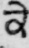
ਕੇ
